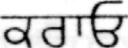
ਕਰਾਓ
